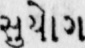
સુયોગ
